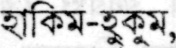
হাকিম-হুকুম,
